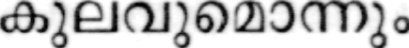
കുലവുമൊന്നും
